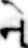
ને
